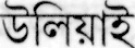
উলিয়াই
